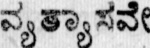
ವ್ಯತ್ಯಾಸವೇ
